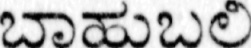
ಬಾಹುಬಲಿ
